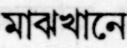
মাঝখানে
